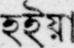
হইয়া
